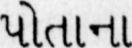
પોતાના
